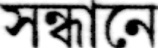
সন্ধানে
